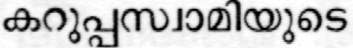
കറുപ്പസ്വാമിയുടെ
